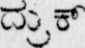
ದ್ರುಕ್
